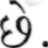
છે.
